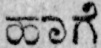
ಹಾಗೆ
